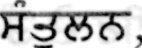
ਸੰਤੁਲਨ,
